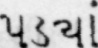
પડ્યાં
